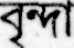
বৃন্দা
